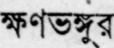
ক্ষণভঙ্গুর
